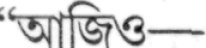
"আজিও-
